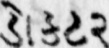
ડોક્ટર
